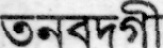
তনবদগী
